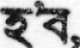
হ'ব,
